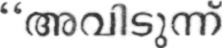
"അവിടുന്ന്
